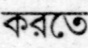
করতে
